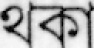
থকা
